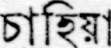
চাহিয়া
